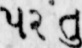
પરંતુ
